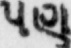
પણ
